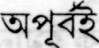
অপূৰ্বই
